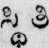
ಸ್ಥಿತಿ
